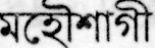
মহৌশাগী
